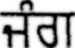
ਜੰਗ
